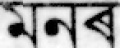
মনৰ
